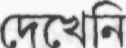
দেখেনি
